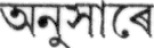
অনুসাৰে
